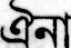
ঐনা
